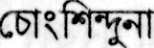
চোংশিন্দুনা
